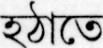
হঠাতে
